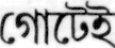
গোটেই
